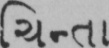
ચિન્તા
